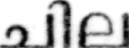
ചില
